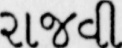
રાજવી
